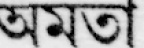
অমতা
